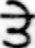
ਤੇ
